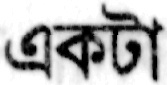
একটা
